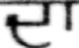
ਦਾ
